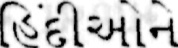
હિંદીઓને
